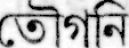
তৌগনি
